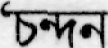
'চন্দন
